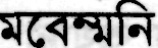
মবেম্মনি
